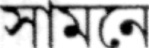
সামনে
